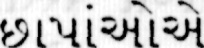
છાપાંઓએ
